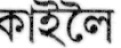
কাইলৈ
